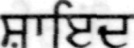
ਸ਼ਾਇਦ
